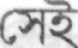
সেই
